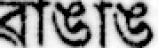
ৱাঙাঙ
